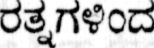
ರತ್ನಗಳಿಂದ
